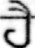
ਹੈ
